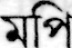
মপি
